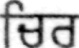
ਚਿਰ
